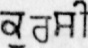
ਕੁਰਸੀ
